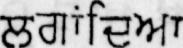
ਲਗਾਂਦਿਆ
